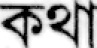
কথা
